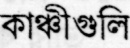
কাঞ্চীগুলি
